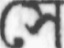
সে
